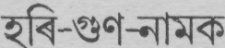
হৰি-গুণ-নামক
